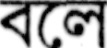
বলে
